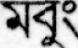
মবুং
